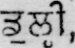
ਡੁਲ੍ਹੀ,
